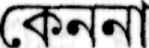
কেননা
